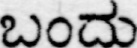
ಬಂದು
